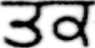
ਤਕ
